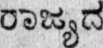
ರಾಜ್ಯದ
